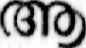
ആ
